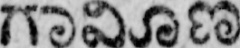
ಗ್ರಾಮೀಣ
